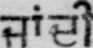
ਜਾਂਦੀ
